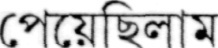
পেয়েছিলাম
